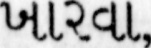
ખારવા,
